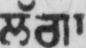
ਲੱਗਾ
